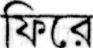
ফিরে
